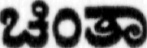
ಚಿಂತಾ
